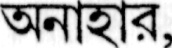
অনাহার,
